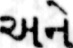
અને
